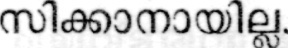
സിക്കാനായില്ല.
